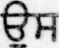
ਉਸ
